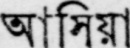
আসিয়া
